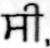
ਸੀ,
